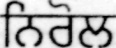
ਨਿਰੋਲ
